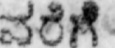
ವರೆಗೆ
